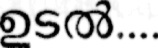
ഉടല്‍....
